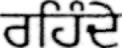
ਰਹਿੰਦੇ
